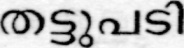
തട്ടുപടി
